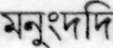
মনুংদদি
